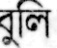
বুলি
